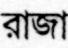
রাজা
